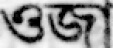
ওজা
